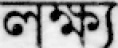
লক্ষ্য
